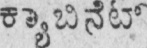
ಕ್ಯಾಬಿನೆಟ್
